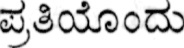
ಪ್ರತಿಯೊಂದು
